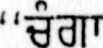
''ਚੰਗਾ
